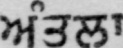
ਅੰਤਲਾ
